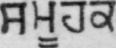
ਸਮੂਹਕ
